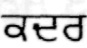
ਕਦਰ
